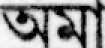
অমা
